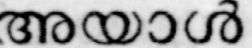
അയാള്‍
